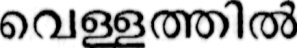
വെള്ളത്തില്‍
